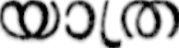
യാത്ര
